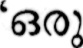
'ഒരു
